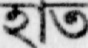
হাত
